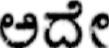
ಅದೇ
